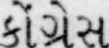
કોંગ્રેસ
